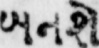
બનશે
